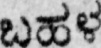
ಬಹಳ
